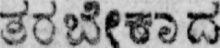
ತರಬೇಕಾದ
